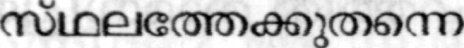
സ്ഥലത്തേക്കുതന്നെ
